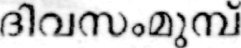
ദിവസംമുമ്പ്
